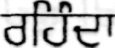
ਰਹਿੰਦਾ
